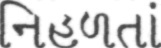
નિહળતાં
